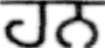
ਹਨ
